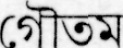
গৌতম
